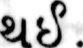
થઈ.
